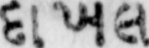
દાખલ
